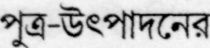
পুত্র-উত্পাদনের
